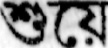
শুয়ে
